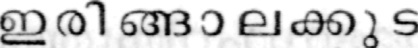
ഇരിങ്ങാലക്കുട
